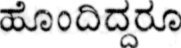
ಹೊಂದಿದ್ದರೂ
